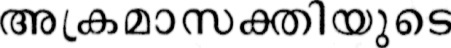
അക്രമാസക്തിയുടെ
